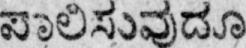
ಪಾಲಿಸುವುದೂ
